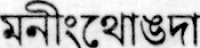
মনীংথোঙদা
